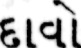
દાવો
